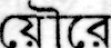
য়ৌরে
